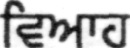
ਵਿਆਹ
